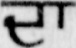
ਦਾ
